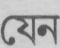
যেন
